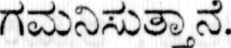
ಗಮನಿಸುತ್ತಾನೆ.
